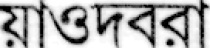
য়াওদবরা
